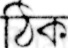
ঠিক
